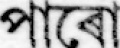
পাৰো
